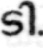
ടി.
